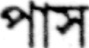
পাস
